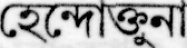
হেন্দোক্তুনা
